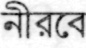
নীরবে
